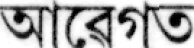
আৱেগত
